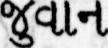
જુવાન
